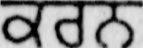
ਕਰਨ
